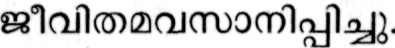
ജീവിതമവസാനിപ്പിച്ചു.
